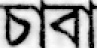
চাবা
